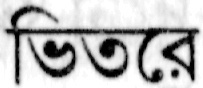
ভিতরে
